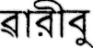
ৱারীবু
